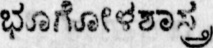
ಭೂಗೋಳಶಾಸ್ತ್ರ
